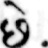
છે.
